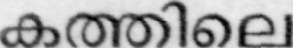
കത്തിലെ
